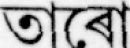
তাৰো
